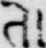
તો
